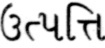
ઉત્પત્તિ
